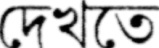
দেখতে
